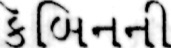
કૅબિનની
